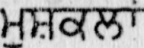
ਮੁਸ਼ਕਲਾਂ
